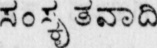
ಸಂಸ್ಕೃತವಾದಿ
